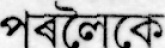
পৰলৈকে
